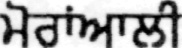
ਮੋਰਾਂਆਲੀ
